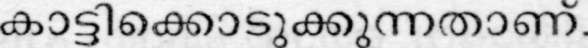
കാട്ടിക്കൊടുക്കുന്നതാണ്.
